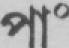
পা
